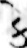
કે
